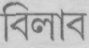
বিলাব
